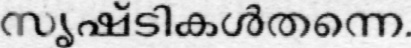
സൃഷ്ടികള്‍തന്നെ.
